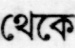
থেকে
